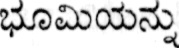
ಭೂಮಿಯನ್ನು
